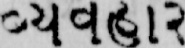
વ્યવહાર
